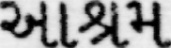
આશ્રમ
